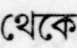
থেকে
